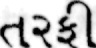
તરફી
